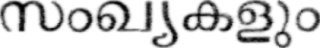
സംഖ്യകളും
